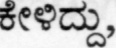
ಕೇಳಿದ್ದು,
